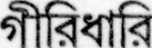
গীরিধারি
